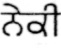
ਨੇਕੀ
